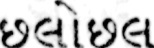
છલોછલ
